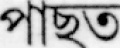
পাছত
